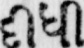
દીધી
